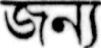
জন্য
